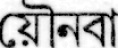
য়ৌনবা
